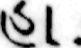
હા.
